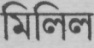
মিলিল
